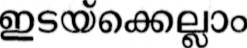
ഇടയ്ക്കെല്ലാം
